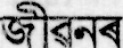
জীৱনৰ
